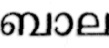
ബാല
